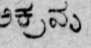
ಅಕ್ರಮ
